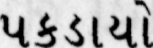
પકડાયો
